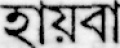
হয়বা
